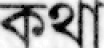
কথা
